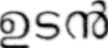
ഉടന്‍
